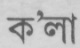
ক'লা
